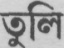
তুলি
